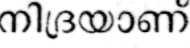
നിദ്രയാണ്
